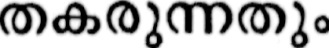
തകരുന്നതും
